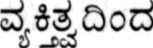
ವ್ಯಕ್ತಿತ್ವದಿಂದ
